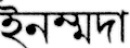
ইনম্মদা
